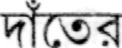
দাঁতের
